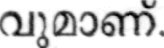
വുമാണ്.
